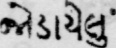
જોડાયેલું
